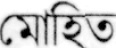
মোহিত
